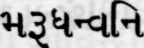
મરૂધન્વનિ
